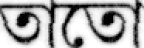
তাতো
